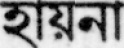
হায়না
